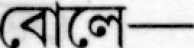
বোলে-
